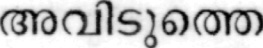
അവിടുത്തെ
